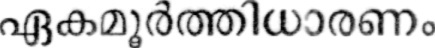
ഏകമൂര്‍ത്തിധാരണം
